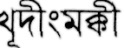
খূদীংমক্কী
